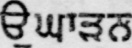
ਉਘਾੜਨ
